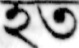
হত
